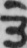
ਤੇ
